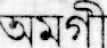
অমগী
